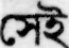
সেই
